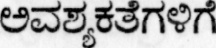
ಅವಶ್ಯಕತೆಗಳಿಗೆ
